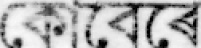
কোবেৰে
